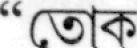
"তোক
